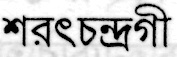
শরৎচন্দ্রগী
